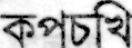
কপচখি
